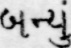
બન્યું
